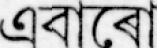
এবাৰো
